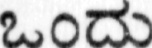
ಒಂದು
